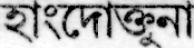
হাংদোক্তুনা
